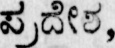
ಪ್ರದೇಶ,
